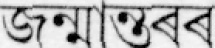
জন্মান্তৰৰ
